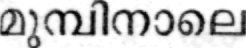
മുമ്പിനാലെ
